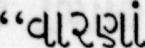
"વારણાં
